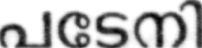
പടേനി
